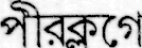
পীরক্লগে
